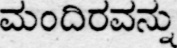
ಮಂದಿರವನ್ನು
